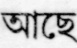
আছে
